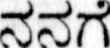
ನನಗೆ
